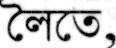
লৈতে,
